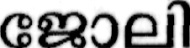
ജോലി
